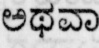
ಅಥವಾ
